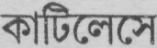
কাটিলেসে
